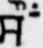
ਸੌਂ
